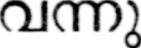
വന്നു
